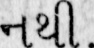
નથી.
